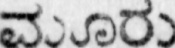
ಮೂರು
